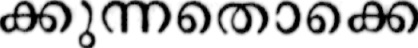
ക്കുന്നതൊക്കെ
